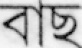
বাছ
